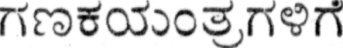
ಗಣಕಯಂತ್ರಗಳಿಗೆ
